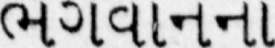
ભગવાનના
